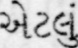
એટલું
